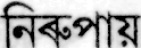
নিৰুপায়
